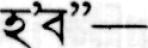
হ'ব"-
